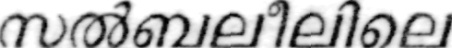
സല്‍ബലീലിലെ
